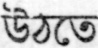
উঠতে
